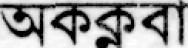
অকক্নবা
